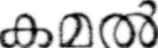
കമല്‍
